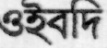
ওইবদি
